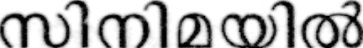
സിനിമയില്‍
